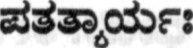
ಪತತ್ಯಾರ್ಯಃ
